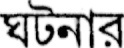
ঘটনার
